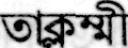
তাক্লম্মী
